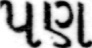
પણ
